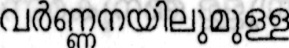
വര്‍ണ്ണനയിലുമുള്ള
